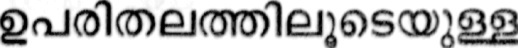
ഉപരിതലത്തിലൂടെയുള്ള
